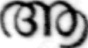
ആ
